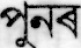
পুনৰ
